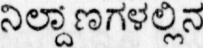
ನಿಲ್ದಾಣಗಳಲ್ಲಿನ
